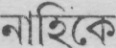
নাহিকে
